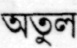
অতুল
